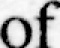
of
